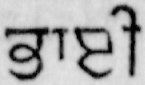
ਭਾਈ
